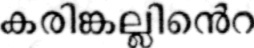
കരിങ്കല്ലിന്റെ
